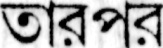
তারপর
